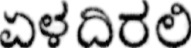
ಏಳದಿರಲಿ
